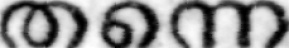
തന്നെ
